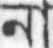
না
